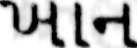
ખાન
